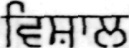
ਵਿਸ਼ਾਲ
